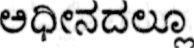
ಅಧೀನದಲ್ಲೂ
